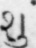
શું
